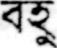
বহু
